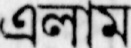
এলাম
